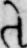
તે
